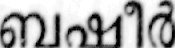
ബഷീര്‍
